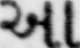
આ
